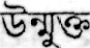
উন্মুক্ত
